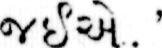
જઈએ.'
